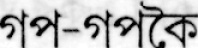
গপ-গপকৈ
